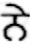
ਨੇ
